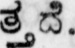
ತ್ತದೆ.
